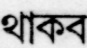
থাকব
